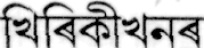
খিৰিকীখনৰ
